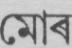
মোৰ
